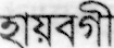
হায়বগী
